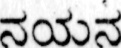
ನಯನ
